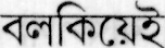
বলকিয়েই
